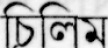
চিলিম
